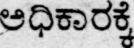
ಅಧಿಕಾರಕ್ಕೆ
